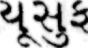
યૂસુફ
